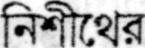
নিশীথের
